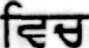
ਵਿਚ
